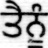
ਤੈਨੂੰ
